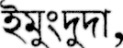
ইমুংদুদা,
